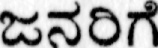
ಜನರಿಗೆ
